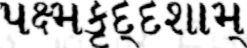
પક્ષ્મકૃદદશામ્
